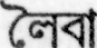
লৈবা
